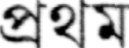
প্রথম
